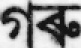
গৰু
